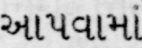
આપવામાં
